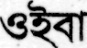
ওইবা
